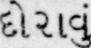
દોરાવું
